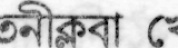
হংলকপনি
